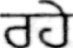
ਰਹੇ
